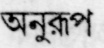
অনুরূপ
